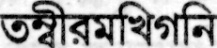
তম্বীরমখিগনি
